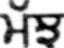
ਮੱਝ
